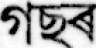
গছৰ
